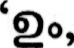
‘ഉം,
